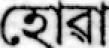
হোৱা
